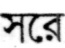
সরে
